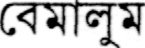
বেমালুম
